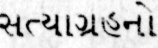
સત્યાગ્રહનો
